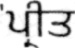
'ਪ੍ਰੀਤ
